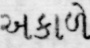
અકાળે
